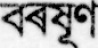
বৰষূণ
